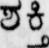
ಶಕ್ತಿ
